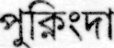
পুক্নিংদা
